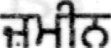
ਜ਼ਮੀਨ
